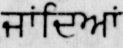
ਜਾਂਦਿਆਂ
